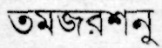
তমজরশনু
